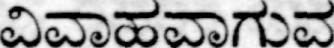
ವಿವಾಹವಾಗುವ
